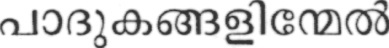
പാദുകങ്ങളിന്മേല്‍
